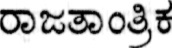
ರಾಜತಾಂತ್ರಿಕ
